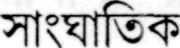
সাংঘাতিক
